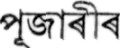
পূজাৰীৰ
